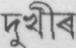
দুখীৰ
